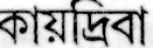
কায়দ্রিবা
